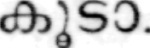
കൂടാ.
